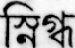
স্নিগ্ধ
